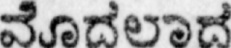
ಮೊದಲಾದ
